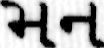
મન
